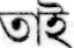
তাই
